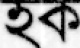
হক
